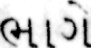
ભાગે
